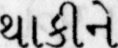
થાકીને
